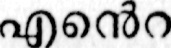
എന്റെ
